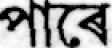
পাৰে
